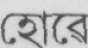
হোৱে
